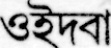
ওইদবা
